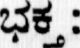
ಭಕ್ತ:
